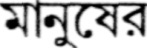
মানুষের
